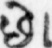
છો
